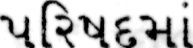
પરિષદમાં
